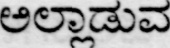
ಅಲ್ಲಾಡುವ
